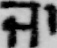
ਜਾ
